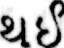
થઈ
